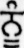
ਨੂੰ
